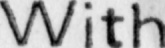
With
